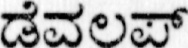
ಡೆವಲಪ್
